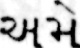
અમે
